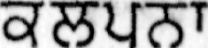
ਕਲਪਨਾ
